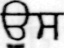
ਉਸ
